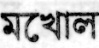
মখোল
